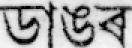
ডাঙৰ
